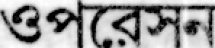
ওপরেসন
